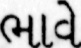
ભાવે
